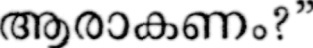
ആരാകണം?"
